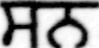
ਸਨ
